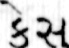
કેસ
